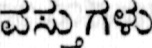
ವಸ್ತುಗಳು
